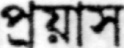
প্রয়াস
